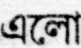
এলো
